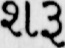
શરૂ
